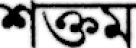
শক্তম
